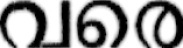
വരെ
